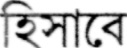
হিসাবে
